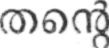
തന്റെ
